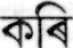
কৰি
